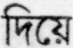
দিয়ে
